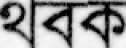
থবক
